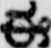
ಈ
